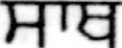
ਸਾਥ
